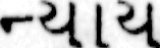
ન્યાય
